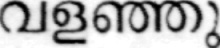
വളഞ്ഞു
